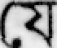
যে
